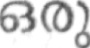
ഒരു
